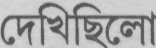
দেখিছিলো
